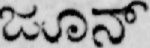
ಜೂನ್
